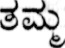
ತಮ್ಮ
